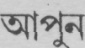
আপুন
